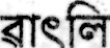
ৱাৎলি
